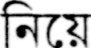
নিয়ে
